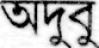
অদুবু
